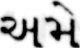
અમે
